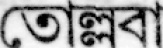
তোল্লবা
